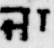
ਜਾ
